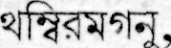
থম্বিরমগনু,
